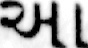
આ
